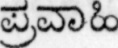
ಪ್ರವಾಹಿ
